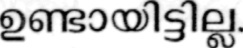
ഉണ്ടായിട്ടില്ല.
